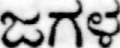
ಜಗಳ
